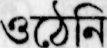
ওঠেনি
